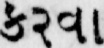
કરવા
